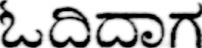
ಓದಿದಾಗ
